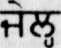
ਜੇਲ੍ਹ
